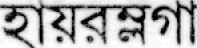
হায়রম্লগা
